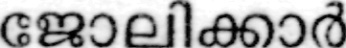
ജോലിക്കാര്‍
